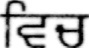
ਵਿਚ
